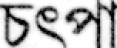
চৎপা
